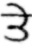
ਤੇ
